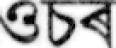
ওচৰ
